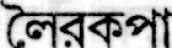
লৈরকপা
